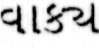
વાક્ય
